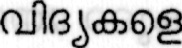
വിദ്യകളെ
